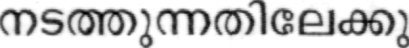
നടത്തുന്നതിലേക്കു
